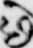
છે
